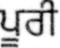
ਪੂਰੀ
